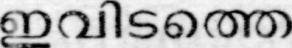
ഇവിടത്തെ
